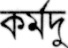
কর্মদু
